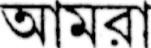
আমরা
